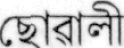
ছোৱালী
